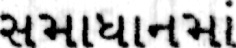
સમાધાનમાં
